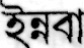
ইন্নবা
